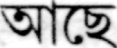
আছে
